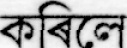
কৰিলে
